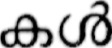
കള്‍
